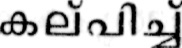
കല്പിച്ച്
